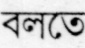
বলতে
